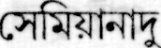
সেমিয়ানাদু
